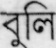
বুলি
